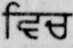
ਵਿਚ
